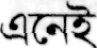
এনেই
